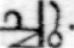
ച്ചു.
